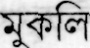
মুকলি
